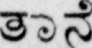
ತಾನೆ
